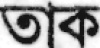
তাক
